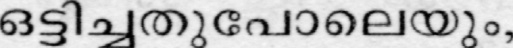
ഒട്ടിച്ചതുപോലെയും,
